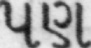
પણ
